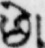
છો
